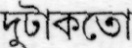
দুটাকতো
